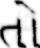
તો
